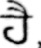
ਹੈ,
